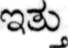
ಇತ್ತು
